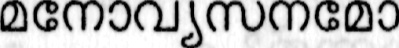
മനോവ്യസനമോ
